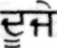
ਦੂਜੇ
